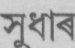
সুধাৰ
